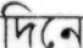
দিনে
